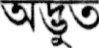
অদ্ভুত
